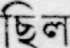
ছিল
